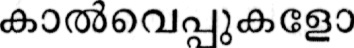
കാല്‍വെപ്പുകളോ
